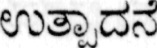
ಉತ್ಪಾದನೆ
